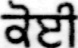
ਕੋਈ
